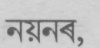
নয়নৰ,
